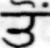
ਤੋਂ
